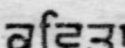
ਕਵਿਤਾ
